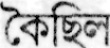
কৈছিল
